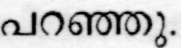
പറഞ്ഞു.
